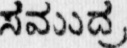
ಸಮುದ್ರ
